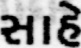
સાહે
